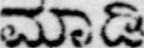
ಮಾಡಿ
